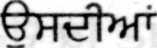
ਉਸਦੀਆਂ
